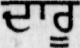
ਦਾਰੂ
